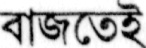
বাজতেই
